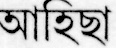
আহিছা
